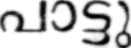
പാട്ടു
